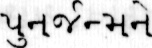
પુનર્જન્મને
